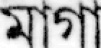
মাগা
